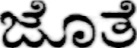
ಜೊತೆ
